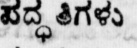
ಪದ್ಧತಿಗಳು
